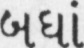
બધાં
